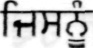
ਜਿਸਨੂੰ
